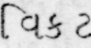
વિકટ
